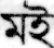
মই
